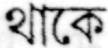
থাকে
